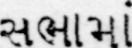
સભામાં
